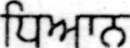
ਧਿਆਨ
